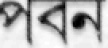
পবন
